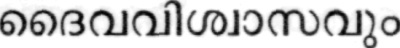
ദൈവവിശ്വാസവും
